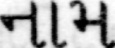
નામ
